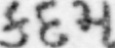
કદમ
